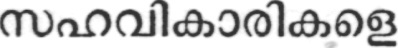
സഹവികാരികളെ
